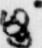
છું
